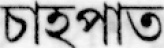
চাহপাত
